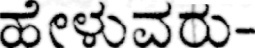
ಹೇಳುವರು-
